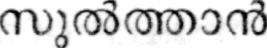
സുല്‍ത്താന്‍
